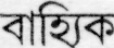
বাহ্যিক
